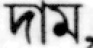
দাম,
